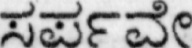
ಸರ್ಪವೇ
